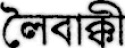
লৈবাক্কী
